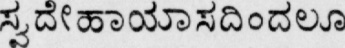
ಸ್ವದೇಹಾಯಾಸದಿಂದಲೂ
